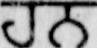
ਹਨ
